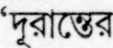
‘দূরান্তের
